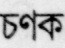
চণক
